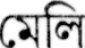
মেলি
